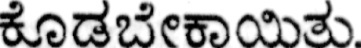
ಕೊಡಬೇಕಾಯಿತು.
